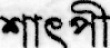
শাৎপী
